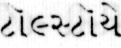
ટૉલ્સટૉયે
